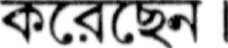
করেছেন।
